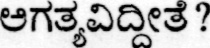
ಅಗತ್ಯವಿದ್ದೀತೆ?
